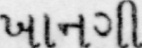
ખાનગી
